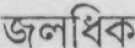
জলধিক
